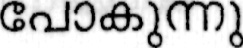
പോകുന്നു
